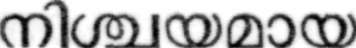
നിശ്ചയമായ
